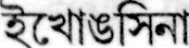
ইখোঙসিনা
